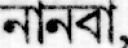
নানবা,
